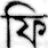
ফি
